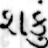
શકું
